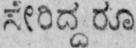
ಸೇರಿದ್ದರೂ
